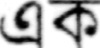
এক
